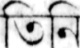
তিনি
